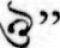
ঔ"
